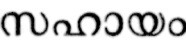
സഹായം
